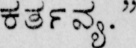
ಕರ್ತವ್ಯ.”
